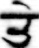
ਤੇ
